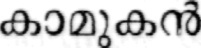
കാമുകന്‍
